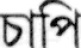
চাপি
